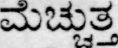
ಮೆಚ್ಚುತ್ತ
